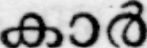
കാര്‍
